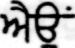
ਐਉਂ
